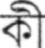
কী
